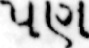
પણ
